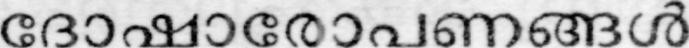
ദോഷാരോപണങ്ങള്‍
